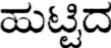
ಹುಟ್ಟಿದ
